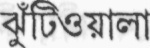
ঝুঁটিওয়ালা
